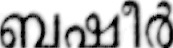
ബഷീര്‍
